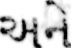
અને
